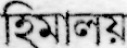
হিমালয়
